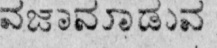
ವಜಾಮಾಡುವ
